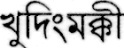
খুদিংমক্কী
